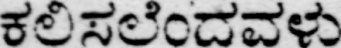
ಕಲಿಸಲೆಂದವಳು
